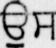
ਉਸ
